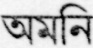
অমনি
